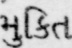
મુક્તિ
